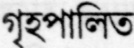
গৃহপালিত
